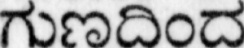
ಗುಣದಿಂದ
